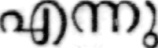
എന്നു
